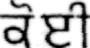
ਕੋਈ
